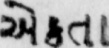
એકતા
